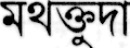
মথক্তুদা
